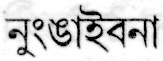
নুংঙাইবনা
